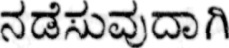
ನಡೆಸುವುದಾಗಿ
